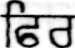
ਫਿਰ
